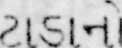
ટાડાનો
